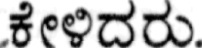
ಕೇಳಿದರು.
